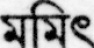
মমিৎ
